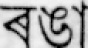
ৰঙা
